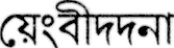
য়েংবীদদনা
